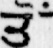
ਤੋਂ
